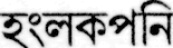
হংলকপনি
